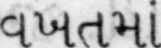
વખતમાં
